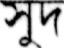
সুদ
